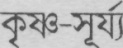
কৃষ্ণ-সূৰ্য্য
